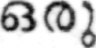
ഒരു
